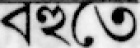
বহুতে
